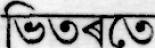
ভিতৰতে
